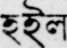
হইল
